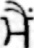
ਮੈਂ
